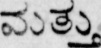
ಮತ್ತು
